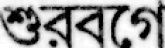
শুরবগে
